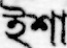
ইশা
